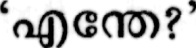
‘എന്തേ?’
